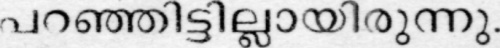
പറഞ്ഞിട്ടില്ലായിരുന്നു.
